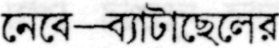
নেবে—ব্যাটাছেলের
